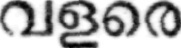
വളരെ
